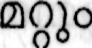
മറ്റും
